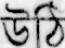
উঠি
